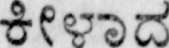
ಕೀಳಾದ
